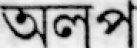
অলপ
